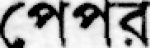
পেপর
